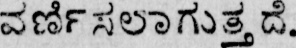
ವರ್ಣಿಸಲಾಗುತ್ತದೆ.
